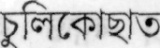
চুলিকোছাত
